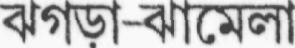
ঝগড়া-ঝামেলা
